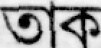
তাক
